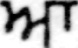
ਆ
